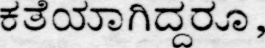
ಕತೆಯಾಗಿದ್ದರೂ,
